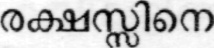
രക്ഷസ്സിനെ
